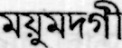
ময়ুমদগী
